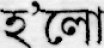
হ'লো
